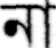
না
